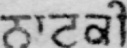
ਨਾਟਕੀ
